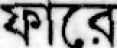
ফারে
